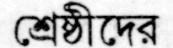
শ্রেষ্ঠীদের
